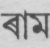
ৰাম
